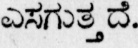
ಎಸಗುತ್ತದೆ.
